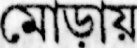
মোড়ায়
